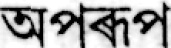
অপৰূপ
